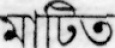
মাটিত
